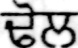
ਢੋਲ
